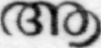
ആ
